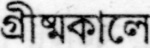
গ্রীষ্মকালে
